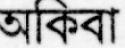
অকিবা
